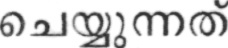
ചെയ്യുന്നത്
